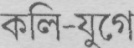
কলি-যুগে
